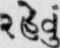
રહેવું
